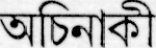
অচিনাকী
